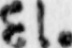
દા.
